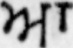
ਆ
